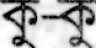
কু-কু
